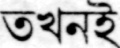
তখনই
